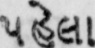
પહેલા
